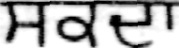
ਸਕਦਾ
